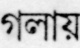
গলায়
